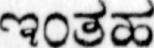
ಇಂತಹ
